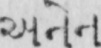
અનેન
